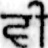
ਵੀ
